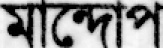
মান্দোপ
